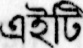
এইটি
